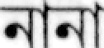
নানা
